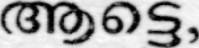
ആട്ടെ,
